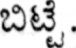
ಬಿಟ್ಟೆ.
